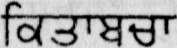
ਕਿਤਾਬਚਾ
